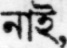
নাই,
